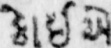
કોઈએ
